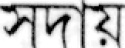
সদায়
